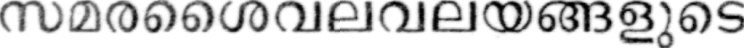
സമരശൈവലവലയങ്ങളുടെ
